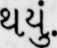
થયું,
